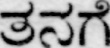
ತನಗೆ
